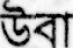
উবা
